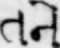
તને
